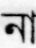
না
